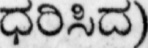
ಧರಿಸಿದ)
